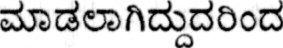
ಮಾಡಲಾಗಿದ್ದುದರಿಂದ
